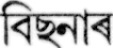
বিছনাৰ
